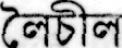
লৈচীল
